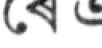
ৰে
